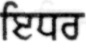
ਇਧਰ
